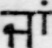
ਜਾਂ
